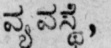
ವ್ಯವಸ್ಥೆ,
